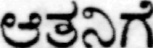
ಆತನಿಗೆ
